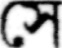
সে
